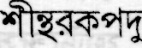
শীন্থরকপদু
